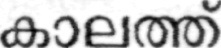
കാലത്ത്
